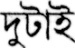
দুটাই
